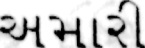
અમારી
